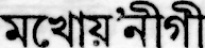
মখোয়’নীগী
